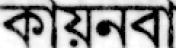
কায়নবা
